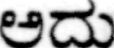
ಅದು
